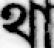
থা
